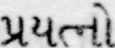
પ્રયત્નો
